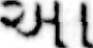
આ
